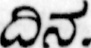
ದಿನ.
